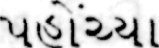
પહોંચ્યા
